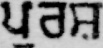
ਪੁਰਸ਼
